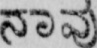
ನಾವು
